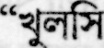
“খুলসি
